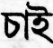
চাই
